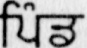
ਪਿੰਡ
